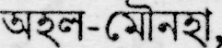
অহল-মৌনহা,
